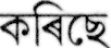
কৰিছে
